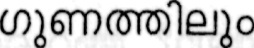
ഗുണത്തിലും
